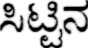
ಸಿಟ್ಟಿನ
